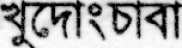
খুদোংচাবা
